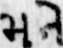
મને
